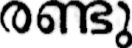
രണ്ടു
